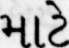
માટે
